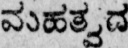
ಮಹತ್ವದ
